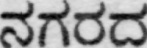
ನಗರದ
